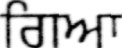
ਗਿਆ
